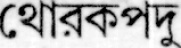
থোরকপদু
